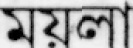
ময়লা
